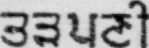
ਤੜਪਣੀ
